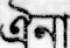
ঐনা
